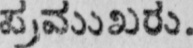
ಪ್ರಮುಖರು.
